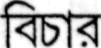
বিচার
